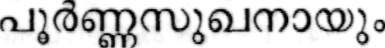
പൂര്‍ണ്ണസുഖനായും
